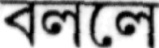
বললে
